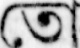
তো
